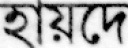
হায়দে
